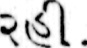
રહી.
